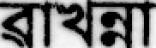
ৱাখন্না
